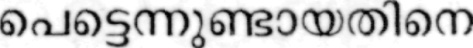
പെട്ടെന്നുണ്ടായതിനെ
